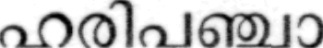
ഹരിപഞ്ചാ
